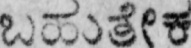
ಬಹುತೇಕ
